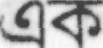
এক
